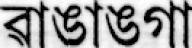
ৱাঙাঙগা
